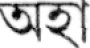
অহা
